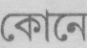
কোনে
